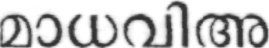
മാധവിഅ
